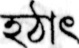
হঠাৎ
